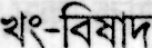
খং-বিষাদ
